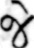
જે
